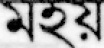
মহয়
